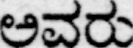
ಅವರು
